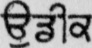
ਉਡੀਕ
